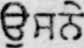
ਉਸਨੇ
